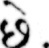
છે.
